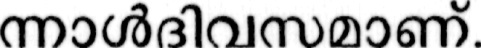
ന്നാള്‍ദിവസമാണ്.
